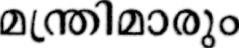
മന്ത്രിമാരും
